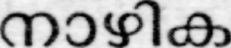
നാഴിക
